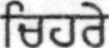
ਚਿਹਰੇ
